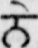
ਨੇ
